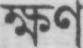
ক্ষণ
